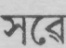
সৱে
